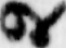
જ
